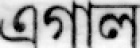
এগাল
